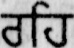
ਰਹਿ
